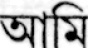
আমি
